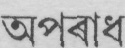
অপৰাধ
